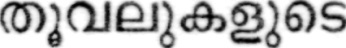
തൂവലുകളുടെ
